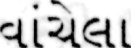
વાંચેલા
